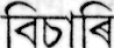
বিচাৰি
